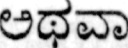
ಅಥವಾ
